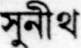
সুনীথ
